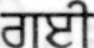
ਗਈ
